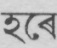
হৰে
